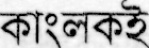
কাংলকই
